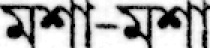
মশা-মশা
